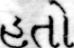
હતો
